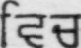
ਵਿਚ
